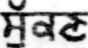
ਸੁੱਕਣ
